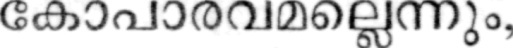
കോപാരവമല്ലെന്നും,
